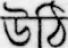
উঠি
